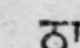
ਨਾ
